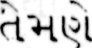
તેમણે
